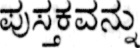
ಪುಸ್ತಕವನ್ನು
